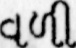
વળી
